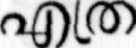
എത്ര
